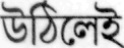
উঠিলেই
